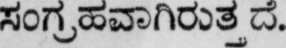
ಸಂಗ್ರಹವಾಗಿರುತ್ತದೆ.
